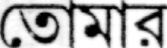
তোমার
